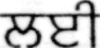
ਲਈ
